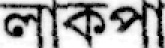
লাকপা
